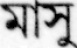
মাসু
